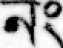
নং
